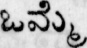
ಒಮ್ಮೆ
